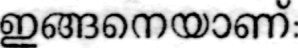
ഇങ്ങനെയാണ്:
